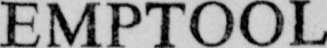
EMPTOOL
